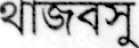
থাজবসু
